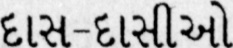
દાસ-દાસીઓ
